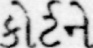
કોર્ટને
